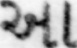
આ
